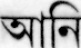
আনি
